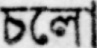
চলো
